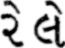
રેલે
